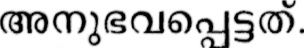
അനുഭവപ്പെട്ടത്.
